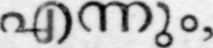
എന്നും,
